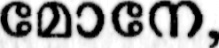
മോനേ,
